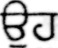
ਉਹ
